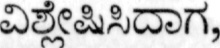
ವಿಶ್ಲೇಷಿಸಿದಾಗ,
